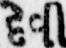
દેવી
